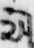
એ
